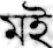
মই
